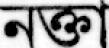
নক্তা
